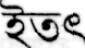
ইতৎ
